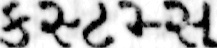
કસ્ટમ્સ
